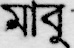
মাবু
